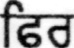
ਫਿਰ
